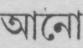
আনো
